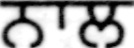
ਨਾਲ
